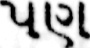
પણ
